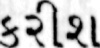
કરીશ
